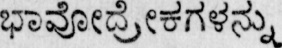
ಭಾವೋದ್ರೇಕಗಳನ್ನು
